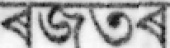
ৰজতৰ
